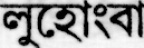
লুহোংবা
